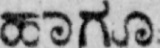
ಹಾಗೂ
